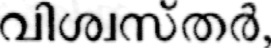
വിശ്വസ്തര്‍,
